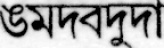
ঙমদবদুদা
